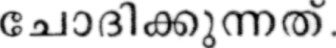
ചോദിക്കുന്നത്.
